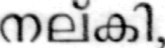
നല്കി,
